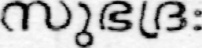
സുഭദ്ര:
